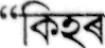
"কিহৰ
